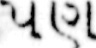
પણ
